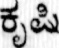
ಕೃಷಿ
